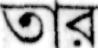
তার
